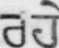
ਰਹੇ
